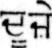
ਦੂਜੇ
